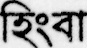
হিংবা
